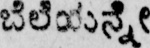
ಬೆಲೆಯನ್ನೇ
